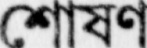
শোষণ
